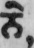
ਨੇ,
